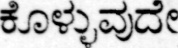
ಕೊಳ್ಳುವುದೇ
